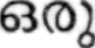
ഒരു
